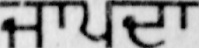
ਜਾਪਦਾ
